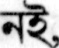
নই,
